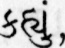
કહ્યું,
